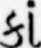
કાં
